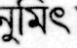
নুমিৎ
